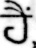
ਹੈਂ,
